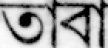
তাবা
